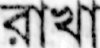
রাখা
